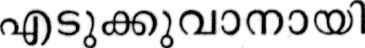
എടുക്കുവാനായി
